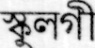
স্কুলগী
